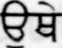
ਉਥੇ
